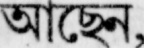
আছেন,
